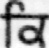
ਕਿ
